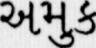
અમુક
